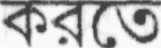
করতে
